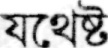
যথেষ্ট
